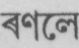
ৰণলে
